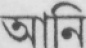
আনি
